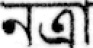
নত্রা
